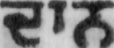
ਦਾਨ
